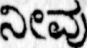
ನೀವು
